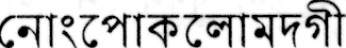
নোংপোকলোমদগী
